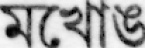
মখোঙ
